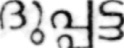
ദുപ്പട്ട
